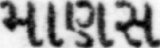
માણસ
